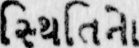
સ્થિતિનો
